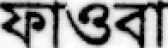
ফাওবা
